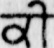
ਕੀ
